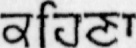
ਕਹਿਣਾ
